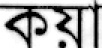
কয়া
